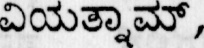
ವಿಯತ್ನಾಮ್,
